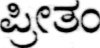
ಪ್ರೀತಂ
